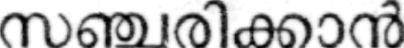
സഞ്ചരിക്കാന്‍
